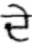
ਦੇ
